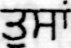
ਤੁਸਾਂ
